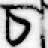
চা
